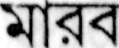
মারব
